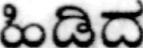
ಹಿಡಿದ
